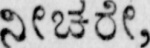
ನೀಚರೇ,
